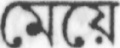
মেয়ে
